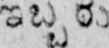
ಇಬ್ಬರು
